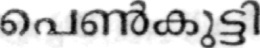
പെണ്‍കുട്ടി
